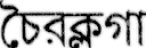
চৈরক্লগা
